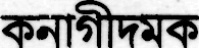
কনাগীদমক
